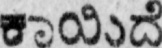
ಕಾಯಿದೆ
